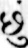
છું
